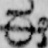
ಈ
